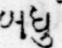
બધું
